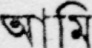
আমি
